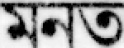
মনত
